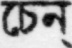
চেন্
